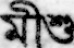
মীশু
